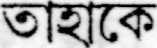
তাহাকে
